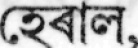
হেৰাল,
